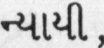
ન્યાયી,
